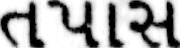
તપાસ
